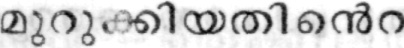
മുറുക്കിയതിന്റെ
